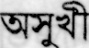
অসুখী
